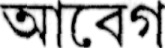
আবেগ
